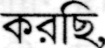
করছি,
